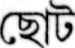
ছোট
